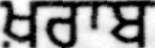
ਖ਼ਰਾਬ
